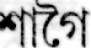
শাগৈ
